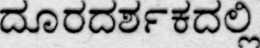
ದೂರದರ್ಶಕದಲ್ಲಿ
